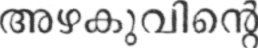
അഴകുവിന്റെ
